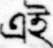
এই
